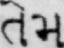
તેમ
